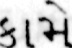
કામે
